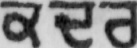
ਕਦਰ
